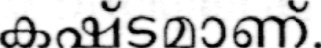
കഷ്ടമാണ്.
